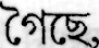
গৈছে,
